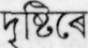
দৃষ্টিৰে
